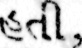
હતી,
